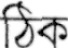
ঠিক
